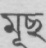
মূছ
